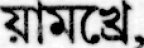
য়ামখ্রে,
